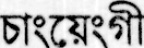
চাংয়েংগী
